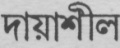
দায়াশীল
